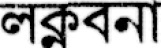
লক্নবনা
